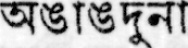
অঙাঙদুনা
